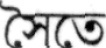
সৈতে
